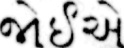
જોઈએ
